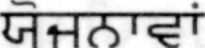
ਯੋਜਨਾਵਾਂ
